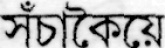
সঁচাকৈয়ে
